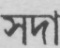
সদা
